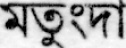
মতুংদা
